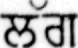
ਲੱਗ
